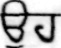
ਉਹ
